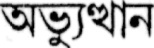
অভ্যুত্থান
